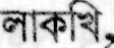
লাকখি,
